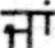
ਜਾਂ
